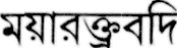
ময়ারক্ত্রবদি
